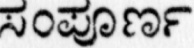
ಸಂಪೂರ್ಣ
